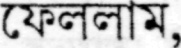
ফেললাম,
